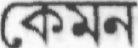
কেমন
